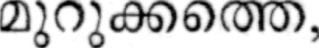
മുറുക്കത്തെ,
